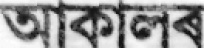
আকালৰ
